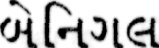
બેનિગલ
